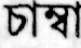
চাম্বা
